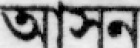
আসন
